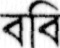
ববি
